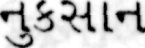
નુકસાન
